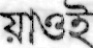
য়াওই
